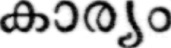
കാര്യം
